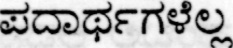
ಪದಾರ್ಥಗಳೆಲ್ಲ
